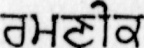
ਰਮਣੀਕ
